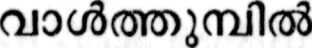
വാള്‍ത്തുമ്പില്‍
